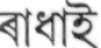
ৰাধাই
